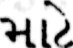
માટે
